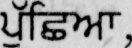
ਪੁੱਛਿਆ,
